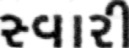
સ્વારી
